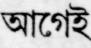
আগেই
